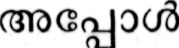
അപ്പോള്‍
